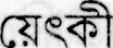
য়েৎকী
